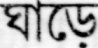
ঘাড়ে
